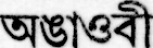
অঙাওবী
